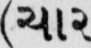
(ચાર
